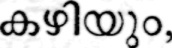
കഴിയും,
